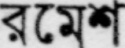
রমেশ
